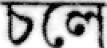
চলে
